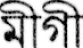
মীগী
